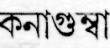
কনাগুম্বা
